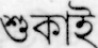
শুকাই
